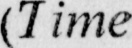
(Time
